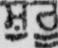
ਸ਼ੁਰੂ
